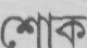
শোক
